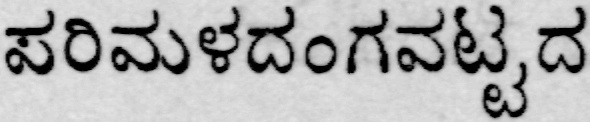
ಪರಿಮಳದಂಗವಟ್ಟದ
